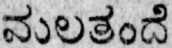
ಮಲತಂದೆ
